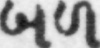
બળ
